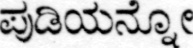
ಪುಡಿಯನ್ನೋ
